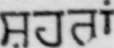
ਸ਼ਹਰਾਂ
